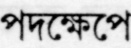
পদক্ষেপে
